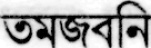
তমজবনি
